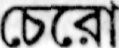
চেরো
